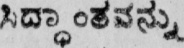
ಸಿದ್ದಾಂತವನ್ನು
